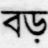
বড়
